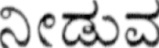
ನೀಡುವ
